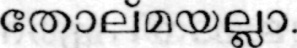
തോല്മയല്ലാ.
